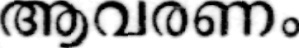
ആവരണം
